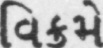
વિક્રમે
